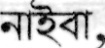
নাইবা,
